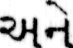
અને
